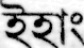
ইহাং
